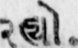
રહ્યો.
